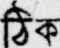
ঠিক
